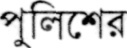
পুলিশের
